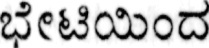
ಭೇಟಿಯಿಂದ
